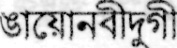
ঙায়োনবীদুগী
